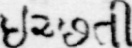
ઈચ્છતી
